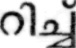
റിച്ച്
